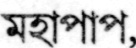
মহাপাপ,
